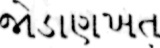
જોડાણખત
